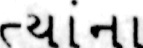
ત્યાંના
